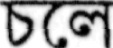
চলে
